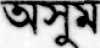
অসুম
